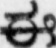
ಈ
